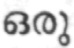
ഒരു
